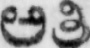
ಅತಿ
